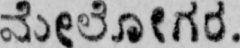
ಮೇಲೋಗರ.
